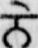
ਨੇ
